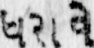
ધરાવે
